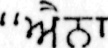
''ਐਨਾ
